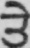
ਤੇ
